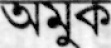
অমুক
